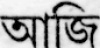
আজি
